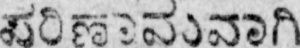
ಪರಿಣಾಮವಾಗಿ
